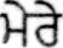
ਮੇਰੇ
